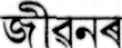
জীৱনৰ
